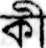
কী
